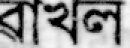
ৱাখল
